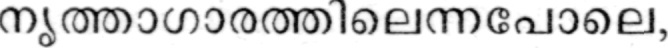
നൃത്താഗാരത്തിലെന്നപോലെ,
